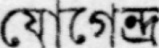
যোগেন্দ্র
